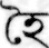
হৈ
